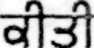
ਕੀਤੀ
